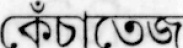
কেঁচাতেজ
